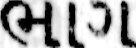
ભાગ
